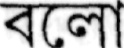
বলো
